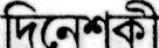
দিনেশকী
